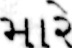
મારે
